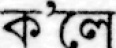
ক'লে
